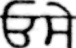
ਓਸੇ
